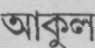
আকুল
